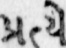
પ્રત્યે
